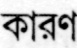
কারণ
